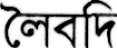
লৈবদি
